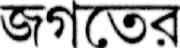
জগতের
